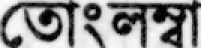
তোংলম্বা
